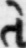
તે
